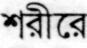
শরীরে
